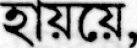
হায়য়ে,
